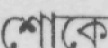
শোকে
